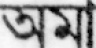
অমা
